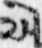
એ
